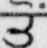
ਤੋਂ
